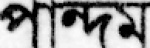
পান্দম
